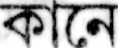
কানে
